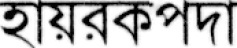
হায়রকপদা
